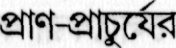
প্রাণ-প্রাচুর্যের
